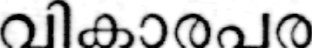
വികാരപര
